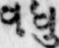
વધુ
